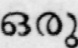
ഒരു
